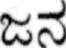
ಜನ
